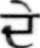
ਦੇ
